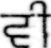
ਵੀ
